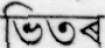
ভিতৰ
